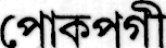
পোকপগী
